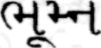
ભૂમ્ન
